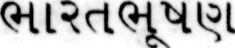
ભારતભૂષણ
